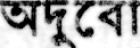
অদুবো
